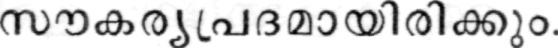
സൌകര്യപ്രദമായിരിക്കും.
